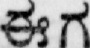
ಈಗ
